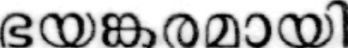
ഭയങ്കരമായി
